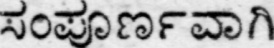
ಸಂಪೂರ್ಣವಾಗಿ
